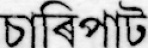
চাৰিপাট
